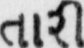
તારી
